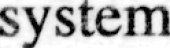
system
